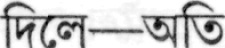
দিলে-অতি
